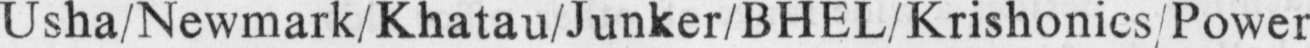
Usha/Newmark/Khatau/Junker/BHEL/Krishonics/Power
